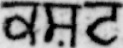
ਕਸ਼ਟ
